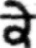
ਕੇ
